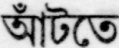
আঁটতে
